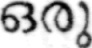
ഒരു
